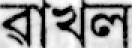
ৱাখল
